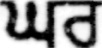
ਘਰ
